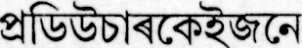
প্রডিউচাৰকেইজনে
